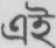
এই
